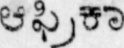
ಆಫ್ರಿಕಾ
